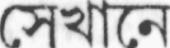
সেখানে
